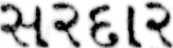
સરદાર
